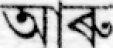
আৰু
